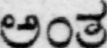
ಅಂತ
